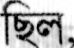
ছিল,
